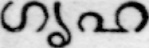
ഗൃഹ
